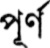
পূর্ণ
